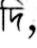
দি,
